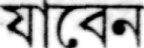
যাবেন
